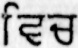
ਵਿਚ
